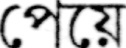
পেয়ে
